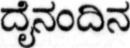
ದೈನಂದಿನ
